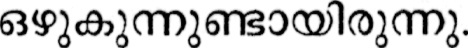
ഒഴുകുന്നുണ്ടായിരുന്നു.
